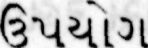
ઉપયોગ
